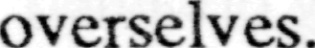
overselves.
